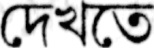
দেখতে
